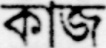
কাজ
